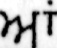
ਆਂ
